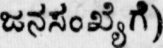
ಜನಸಂಖ್ಯೆಗೆ)
